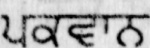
ਪਕਵਾਨ
